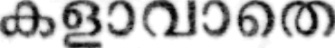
കളാവാതെ
